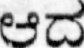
ಆದ
